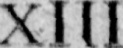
XIII
